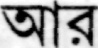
আর
